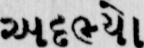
અદભ્યો
